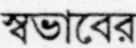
স্বভাবের
